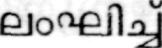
ലംഘിച്ച്
